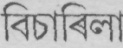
বিচাৰিলা
